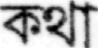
কথা
